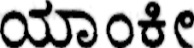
ಯಾಂಕೀ
